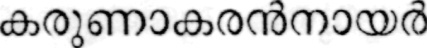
കരുണാകരന്‍നായര്‍
